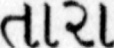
તારા
